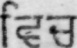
ਵਿਚ
